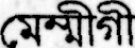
মেম্মীগী
